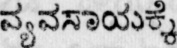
ವ್ಯವಸಾಯಕ್ಕೆ
